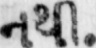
નથી.
